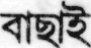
বাছাই
